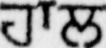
ਹਾਲ
